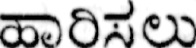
ಹಾರಿಸಲು
